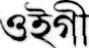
ওইগী
